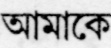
আমাকে
